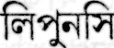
লিপুনসি
